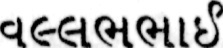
વલ્લભભાઈ
